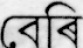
বেৰি
